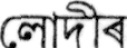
লোদীৰ
